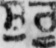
ਸ਼ੁਰੂ
